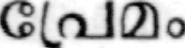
പ്രേമം
